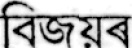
বিজয়ৰ
